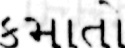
કમાતો
